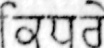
ਕਿਧਰੇ
